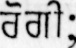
ਰੋਗੀ;
